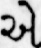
એ
